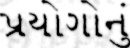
પ્રયોગોનું
